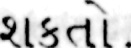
શકતો.
